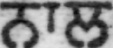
ਨਾਲ
